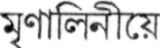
মৃণালিনীয়ে
